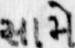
સામે
